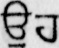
ਉਹ
